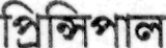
প্রিন্সিপাল
